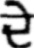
ਦੇ
